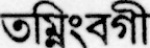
তম্নিংবগী
